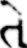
તે
